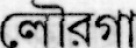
লৌরগা
